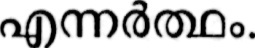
എന്നര്‍ത്ഥം.
